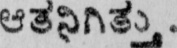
ಆತನಿಗಿತ್ತು.
